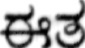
ಈತ
